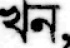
খন,
